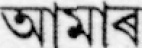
আমাৰ
